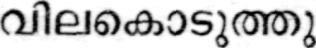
വിലകൊടുത്തു
